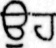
ਉਹ
